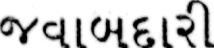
જવાબદારી
